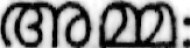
അമ്മ:
